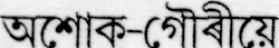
অশোক-গৌৰীয়ে
